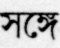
সঙ্গে
